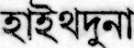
হাইথদুনা
